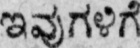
ಇವುಗಳಿಗೆ
